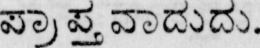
ಪ್ರಾಪ್ತವಾದುದು.
